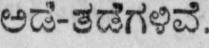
ಅಡೆ-ತಡೆಗಳಿವೆ.
